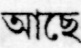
আছে
